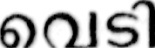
വെടി
